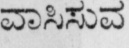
ವಾಸಿಸುವ
